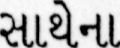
સાથેના
